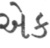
એક
